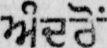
ਅੰਦਰੋਂ
